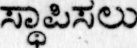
ಸ್ಥಾಪಿಸಲು
